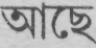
আছে
